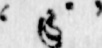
'હં'
